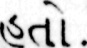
હતો.
